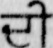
ਦੀ
